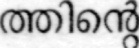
ത്തിന്റെ
